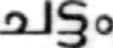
ചട്ടം
